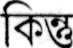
কিন্তু
